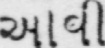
આવી
